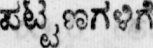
ಪಟ್ಟಣಗಳಿಗೆ
